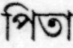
পিতা
